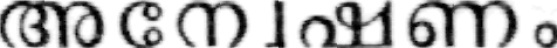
അന്വേഷണം
